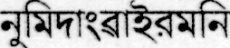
নুমিদাংৱাইরমনি
